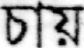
চায়
